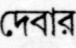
দেবার
